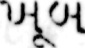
ખૂબ
